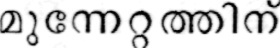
മുന്നേറ്റത്തിന്
